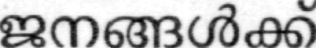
ജനങ്ങള്‍ക്ക്
